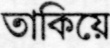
তাকিয়ে
